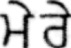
ਮੇਰੇ
